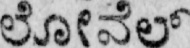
ಲೋವೆಲ್
